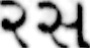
રસ
